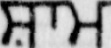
ਸ਼ਾਮ
